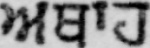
ਅਥਾਹ
